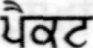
ਪੈਕਟ
